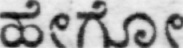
ಹೇಗೋ
